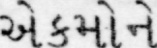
એકમોને
